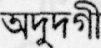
অদুদগী
